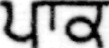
ਪਾਕ
